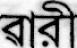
ৱারী
